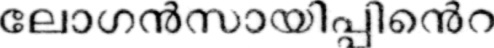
ലോഗന്‍സായിപ്പിന്റെ
